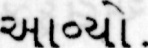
આવ્યો.
